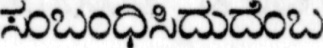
ಸಂಬಂಧಿಸಿದುದೆಂಬ
